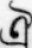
ঐ
